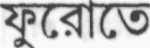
ফুরোতে
